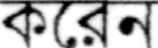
করেন
